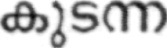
കുടന്ന
